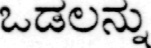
ಒಡಲನ್ನು
